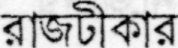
রাজটীকার
